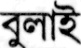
বুলাই
